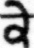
ਕੇ
